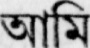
আমি
